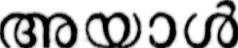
അയാള്‍
